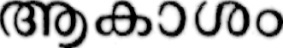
ആകാശം
